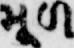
મૂળ
